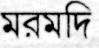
মরমদি
